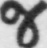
જ
